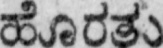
ಹೊರತು
